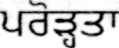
ਪਰੋੜ੍ਹਤਾ
